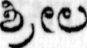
ಶ್ರೀಲ
